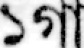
১গা
